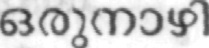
ഒരുനാഴി
